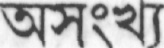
অসংখ্য
